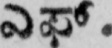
ಎಫ್.
